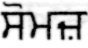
ਸੋਮਜ਼
